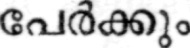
പേര്‍ക്കും
